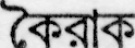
কৈরাক
